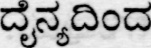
ದೈನ್ಯದಿಂದ
